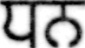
ਧਨ
